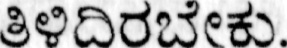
ತಿಳಿದಿರಬೇಕು.
